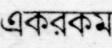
একরকম
